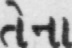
તેના
